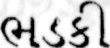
ભડકી
